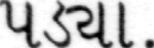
પડ્યા.
